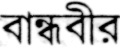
বান্ধবীর
